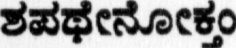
ಶಪಥೇನೋಕ್ತಂ
